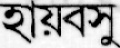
হায়বসু
